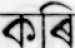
কৰি
